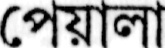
পেয়ালা
